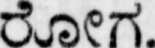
ರೋಗ.
